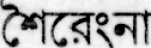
শৈরেংনা
